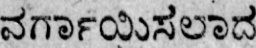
ವರ್ಗಾಯಿಸಲಾದ
